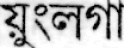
য়ুংলগা
